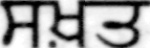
ਸਖ਼ਤ
